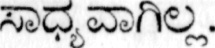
ಸಾಧ್ಯವಾಗಿಲ್ಲ.
